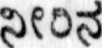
ನೀರಿನ
